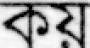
কয়
